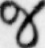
જ
